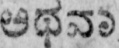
ಅಥವಾ
